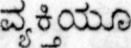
ವ್ಯಕ್ತಿಯೂ
